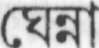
ঘেন্না
